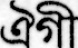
ঐগী
